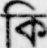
কি
